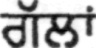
ਗੱਲਾਂ
